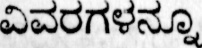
ವಿವರಗಳನ್ನೂ
